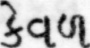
કેવળ
